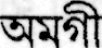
অমীগ
